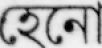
হেনো
